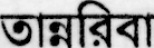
তান্নরিবা
